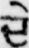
ਦੇ
